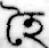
হৈ
